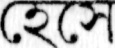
হেসে
